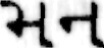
મન
